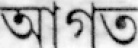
আগত
